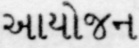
આયોજન
